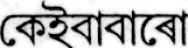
কেইবাবাৰো
